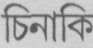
চিনাকি
